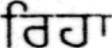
ਰਿਹਾ
